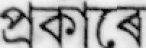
প্রকাৰে
